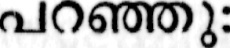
പറഞ്ഞു:
